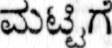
ಮಟ್ಟಿಗೆ
